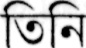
তিনি
